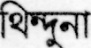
থিন্দুনা
